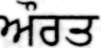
ਔਰਤ
